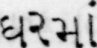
ઘરમાં
